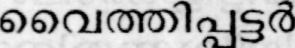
വൈത്തിപ്പട്ടര്‍
